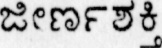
ಜೀರ್ಣಶಕ್ತಿ
